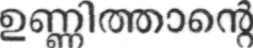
ഉണ്ണിത്താന്റെ
